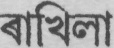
ৰাখিলা
